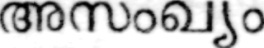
അസംഖ്യം
